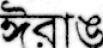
ঈরাঙ
